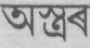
অস্ত্রৰ
